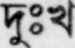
দুঃখ
